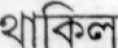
থাকিল
